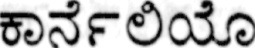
ಕಾರ್ನೆಲಿಯೊ
